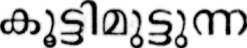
കൂട്ടിമുട്ടുന്ന
